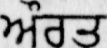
ਔਰਤ
